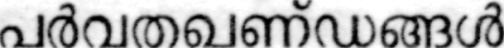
പര്‍വതഖണ്ഡങ്ങള്‍
